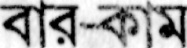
বার-কাম
